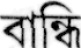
বান্ধি
